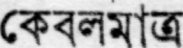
কেবলমাত্র
